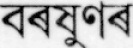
বৰষুণৰ
